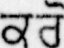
ਕਰੋ
